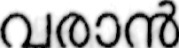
വരാന്‍
